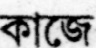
কাজে
